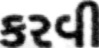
કરવી
